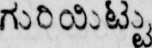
ಗುರಿಯಿಟ್ಟು
